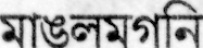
মাঙলমগনি
